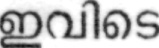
ഇവിടെ
